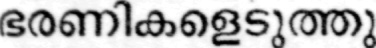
ഭരണികളെടുത്തു
